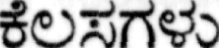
ಕೆಲಸಗಳು
